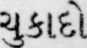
ચુકાદો
